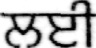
ਲਈ
